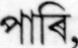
পাৰি,
